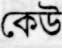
কেউ
